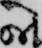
જો
